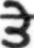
ਤੇ
